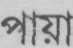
পায়া
